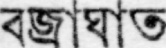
বজ্রাঘাত
